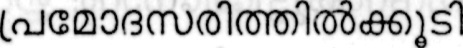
പ്രമോദസരിത്തില്‍ക്കൂടി
